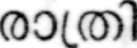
രാത്രി
